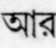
আর
